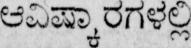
ಆವಿಷ್ಕಾರಗಳಲ್ಲಿ
